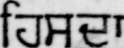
ਹਿਸਦਾ
